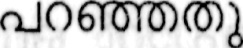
പറഞ്ഞതു
